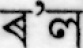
ৰ'ল
